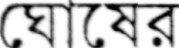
ঘোষের
